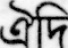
ঐদি
